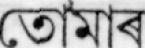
তোমাৰ
